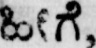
ಹೀಗೆ,
